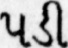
પડી
